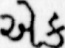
એક
